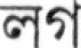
লগ
